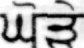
ਘੋੜੇ
